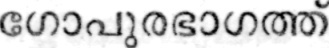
ഗോപുരഭാഗത്ത്
